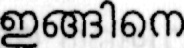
ഇങ്ങിനെ
